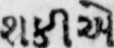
શકીએ
